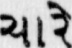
ચારે
